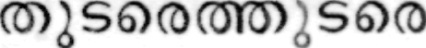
തുടരെത്തുടരെ
